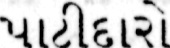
પાટીદારો
